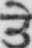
ਤੇ
